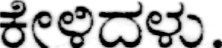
ಕೇಳಿದಳು.
